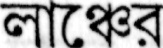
লাঞ্চের
